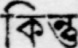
কিন্তু
